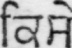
ਕਿਸੇ
